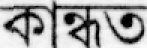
কান্ধত
